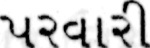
પરવારી
